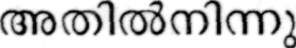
അതില്‍നിന്നു
